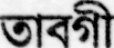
তাবগী
